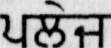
ਪਲੇਜ
